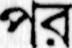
পর
